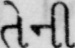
તેની
